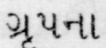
ગ્રૃપના
